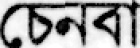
চেনবা
